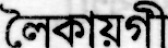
লৈকায়গী
